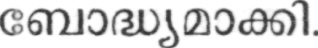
ബോദ്ധ്യമാക്കി.
